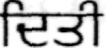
ਦਿਤੀ
